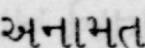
અનામત
